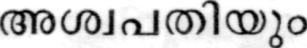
അശ്വപതിയും
